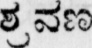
ಶ್ರವಣ
